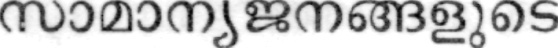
സാമാന്യജനങ്ങളുടെ
